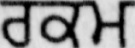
ਰਕਮ
